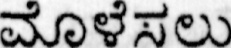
ಮೊಳೆಸಲು
